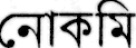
নোকমি
